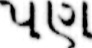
પણ
